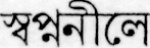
স্বপ্ননীলে
